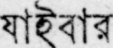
যাইবার
